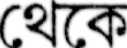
থেকে
